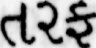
તરફ
